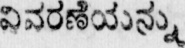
ವಿವರಣೆಯನ್ನು
